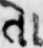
તો
